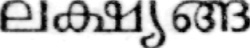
ലക്ഷ്യങ്ങ
